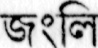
জংলি
